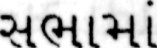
સભામાં
